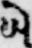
બે
